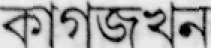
কাগজখন
